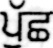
ਪੁੱਛ
